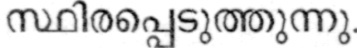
സ്ഥിരപ്പെടുത്തുന്നു.
